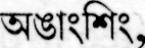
অঙাংশিং,
